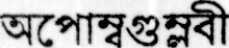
অপোম্বগুম্লবী
